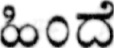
ಹಿಂದೆ
